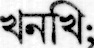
খনখি;
